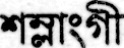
শম্লাংগী
